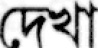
দেখা
